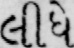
લીધે
